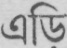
এড়ি
